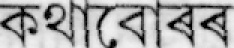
কথাবোৰৰ
